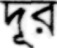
দূর
